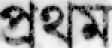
প্রথম
